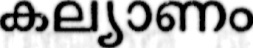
കല്യാണം
